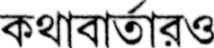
কথাবার্তারও
